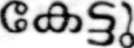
കേട്ടു
